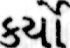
કર્યો
